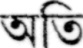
অতি
